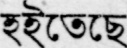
হইতেছে
